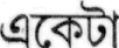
একেটা
